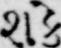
શકે
